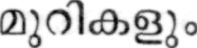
മുറികളും
